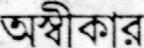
অস্বীকার
